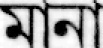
মানা
